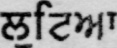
ਲੁਟਿਆ
